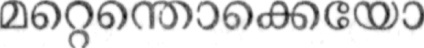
മറ്റെന്തൊക്കെയോ
